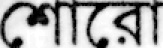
শোরো
